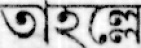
তাহল্লে
